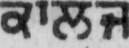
ਕਾਲਜ
